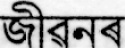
জীৱনৰ
